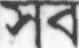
সব
